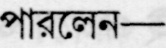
পারলেন–
